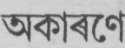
অকাৰণে
